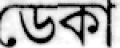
ডেকা
